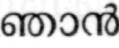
ഞാന്‍
